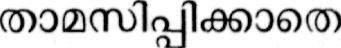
താമസിപ്പിക്കാതെ
